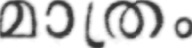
മാത്രം
